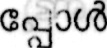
പ്പോള്‍
